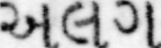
અલગ
